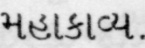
મહાકાવ્ય.
